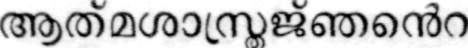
ആത്മശാസ്ത്രജ്ഞന്റെ
